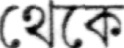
থেকে
